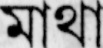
মাথা
